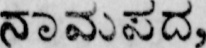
ನಾಮಪದ,
